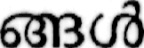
ങ്ങള്‍
